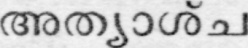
അത്യാശ്ച
